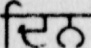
ਦਿਨ
